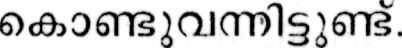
കൊണ്ടുവന്നിട്ടുണ്ട്.
